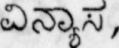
ವಿನ್ಯಾಸ,
